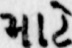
માટે
